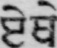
ਏਥੇ
